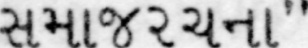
સમાજરચના"
